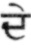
ਦੇ
